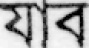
যাব
